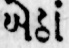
બેઠાં
